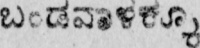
ಬಂಡವಾಳಕ್ಕೂ
